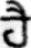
ਹੈ
